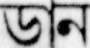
ডান
